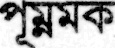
পূম্নমক
